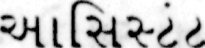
આસિસ્ટંટ
